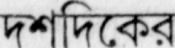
দশদিকের
